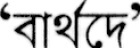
‘বার্থদে’
